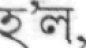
হ'ল,
